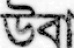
উবা
